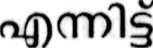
എന്നിട്ട്
